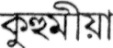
কুহুমীয়া
